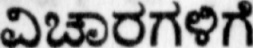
ವಿಚಾರಗಳಿಗೆ
